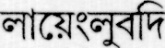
লায়েংলুবদি
